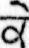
ਕੇ
